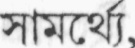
সামর্থ্যে,
